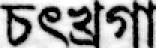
চৎখ্রগা
